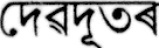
দেৱদূতৰ
